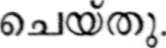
ചെയ്തു.
